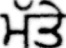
ਮੱਤੇ
